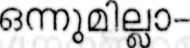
ഒന്നുമില്ലാ-
